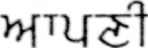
ਆਪਣੀ
